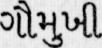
ગૌમુખી
